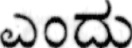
ಎಂದು
